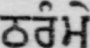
ਠਰੰਮੇ
